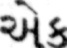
એક
